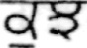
ਕੁਝ
